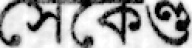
সেকেণ্ড
